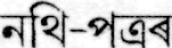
নথি-পত্রৰ
